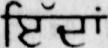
ਇੱਦਾਂ
